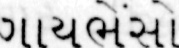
ગાયભેંસો
